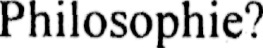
Philosophie?
